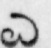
ಎ
